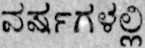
ವರ್ಷಗಳಲ್ಲಿ
